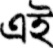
এই
